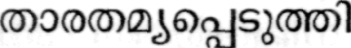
താരതമ്യപ്പെടുത്തി
